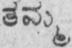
ತಮ್ಮ
